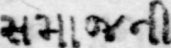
સમાજની
